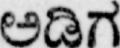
ಅಡಿಗ
